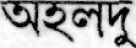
অহলদু
